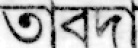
তাবদা
